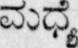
ಮಧ್ಯೆ
